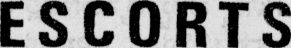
ESCORTS
